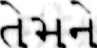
તેમને
